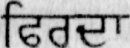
ਫਿਰਦਾ
